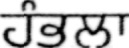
ਹੰਭਲਾ
